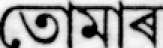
তোমাৰ
